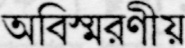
অবিস্মরণীয়
